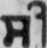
ਸੀ
